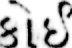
કોઈ
